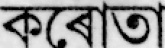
কৰোতা
